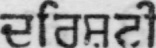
ਦਰਿਸ਼ਟੀ
